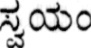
ಸ್ವಯಂ
